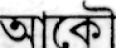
আকৌ
